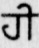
ਹੀ
